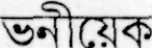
ভনীয়েক
